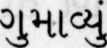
ગુમાવ્યું
